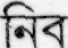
নিব
